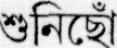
শুনিছোঁ
